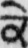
ਕੇ
